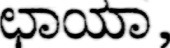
ಛಾಯಾ,
